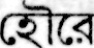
হৌরে
